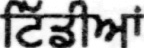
ਟਿੱਡੀਆਂ
